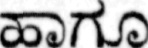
ಹಾಗೂ
